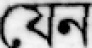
যেন
